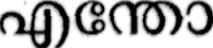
എന്തോ
